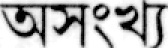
অসংখ্য
